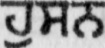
ਹੁਸਨ
